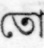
তো
